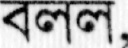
বলল,
